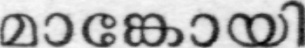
മാങ്കോയി
